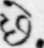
છે.
